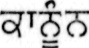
ਕਾਨੂੰਨ
